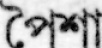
পৈশা
